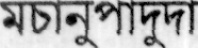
মচানুপাদুদা
